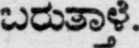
ಬರುತ್ತಾಳೆ.
